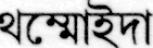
থম্মোইদা
